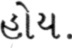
હોય.
